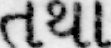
તથા
